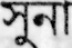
সুনা
